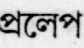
প্রলেপ
